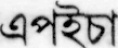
এপইচা
